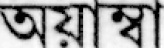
অয়াম্বা
